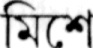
মিশে
